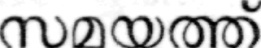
സമയത്ത്
